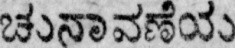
ಚುನಾವಣೆಯ
